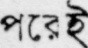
পরেই
